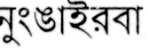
নুংঙাইরবা
